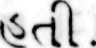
હતી.
